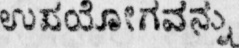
ಉಪಯೋಗವನ್ನು
